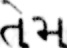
તેમ
